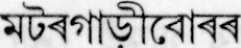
মটৰগাড়ীবোৰৰ
